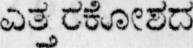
ಎತ್ತರಕೋಶದ
